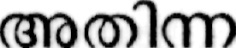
അതിന്ന
